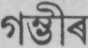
গম্ভীৰ
